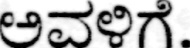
ಅವಳಿಗೆ.
